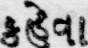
કહેવા
